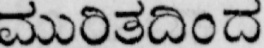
ಮುರಿತದಿಂದ
